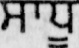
ਸਾਧੂ
